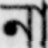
না
